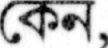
কেন,
